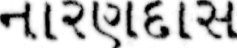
નારણદાસ
